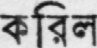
করিল
